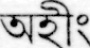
অহীং
